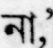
না,’
